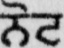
ਨੋਟ
